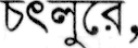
চৎলুরে,
